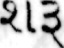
શરૂ
